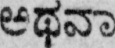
ಅಥವಾ
